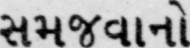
સમજવાનો
